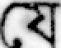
যে
